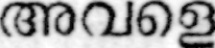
അവളെ
